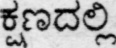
ಕ್ಷಣದಲ್ಲಿ
